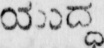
ಯುದ್ಧ
